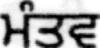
ਮੰਤਵ
